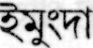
ইমুংদা
